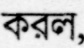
করল,
